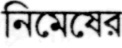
নিমেষের
